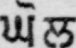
ਘੋਲ
